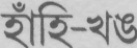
হাঁহি-খঙ
